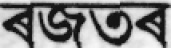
ৰজতৰ
